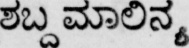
ಶಬ್ದಮಾಲಿನ್ಯ
